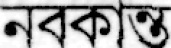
নবকান্তা
